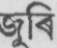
জুৰি
